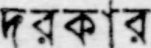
দরকার
